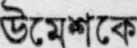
উমেশকে
